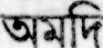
অমদি
